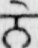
ਨੇ
